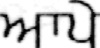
ਆਪੇ
